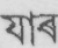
যাৰ
